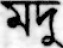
মদু
